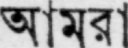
আমরা
